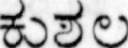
ಕುಶಲ
